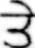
ਤੇ
